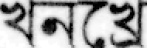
খনখ্রে
